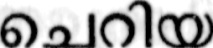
ചെറിയ
